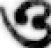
ও
